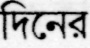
দিনের
